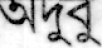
অদুবু
